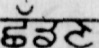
ਛੱਡਣ
